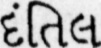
દંતિલ
